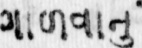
ગાળવાનું
